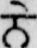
ਨੇ
